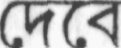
দেবে
